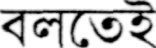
বলতেই
